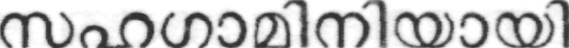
സഹഗാമിനിയായി
